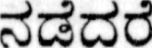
ನಡೆದರೆ
